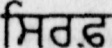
ਸਿਰਫ਼
